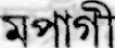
মপাগী
